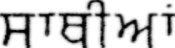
ਸਾਥੀਆਂ
